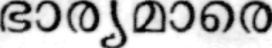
ഭാര്യമാരെ
